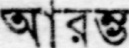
আরম্ভ
